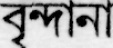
বৃন্দানা
